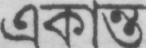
একান্ত
